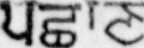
ਪਛਾਣ
